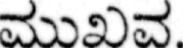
ಮುಖವ.
